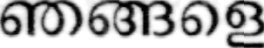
ഞങ്ങളെ
